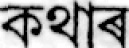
কথাৰ
